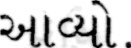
આવ્યો.
